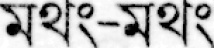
মথং-মথং
